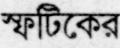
স্ফটিকের
